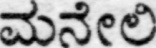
ಮನೇಲಿ
